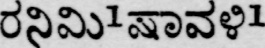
ರನಿಮಿ1ಷಾವಳಿ1
